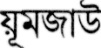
য়ূমজাউ
